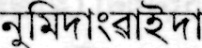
নুমিদাংৱাইদা
